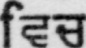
ਵਿਚ
